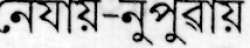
নেযায়-নুপুৱায়
